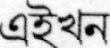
এইখন
